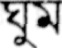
ঘুম
